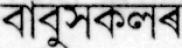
বাবুসকলৰ
